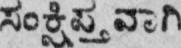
ಸಂಕ್ಷಿಪ್ತವಾಗಿ
